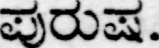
ಪುರುಷ.
